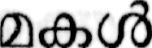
മകള്‍
